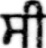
ਸੀ
